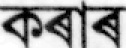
কৰাৰ
